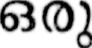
ഒരു
